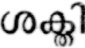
ശക്തി
